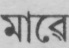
মাৱে
